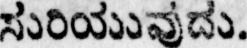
ಸುರಿಯುವುದು.
